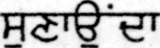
ਸੁਣਾਉਂਦਾ
